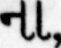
ના,
